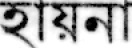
হায়না
